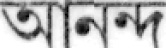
আনন্দ
